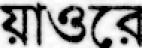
য়াওরে
